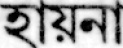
হায়না
